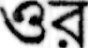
ওর
